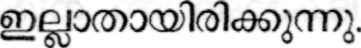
ഇല്ലാതായിരിക്കുന്നു.
